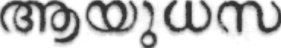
ആയുധസ
